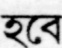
হবে
